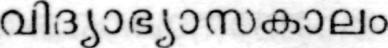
വിദ്യാഭ്യാസകാലം
